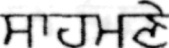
ਸਾਹਮਣੇ
